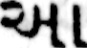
આ
